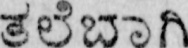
ತಲೆಬಾಗಿ
